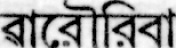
ৱারৌরিবা
